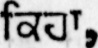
ਕਿਹਾ,
